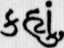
કહ્યું,
